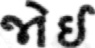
જોઈ
